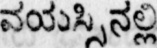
ವಯಸ್ಸಿನಲ್ಲಿ
